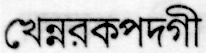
খেন্নরকপদগী
